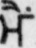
ਮੈਂ
